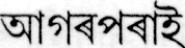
আগৰপৰাই
